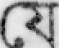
যে
